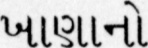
ખાણાનો
